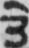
ਤੇ
